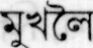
মুখলৈ
